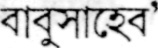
বাবুসাহেব’
